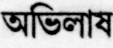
অভিলাষ
